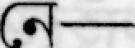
নে-
